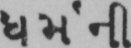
ધર્મની
